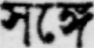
সঙ্গে
